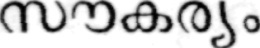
സൌകര്യം
